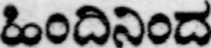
ಹಿಂದಿನಿಂದ
